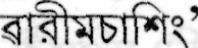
ৱারীমচাশিং’
